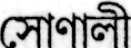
সোণালী
